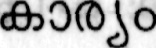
കാര്യം
